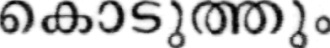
കൊടുത്തും
